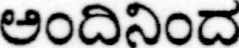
ಅಂದಿನಿಂದ
